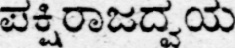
ಪಕ್ಷಿರಾಜದ್ವಯ
